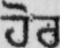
ਹੋਰ
